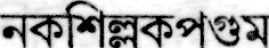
নকশিল্লকপগুম
